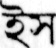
ইস
